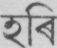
হৰি
